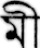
মী
